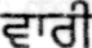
ਵਾਰੀ
